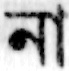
না
